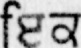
ਇਕ
